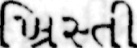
ખ્રિસ્તી
